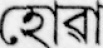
হোৱা
